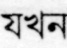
যখন
